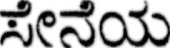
ಸೇನೆಯ
